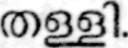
തള്ളി.
